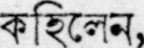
কহিলেন,
